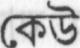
কেউ
